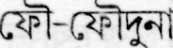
ফৌ-ফৌদুনা
